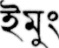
ইমুং
